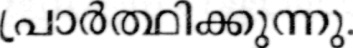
പ്രാര്‍ത്ഥിക്കുന്നു.
